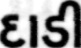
દાડી
